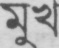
মুখ
